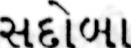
સદોબા
